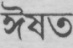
ঈষত
